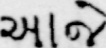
આજે
